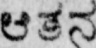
ಆತನ
